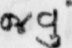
જવું
